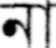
না
